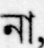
না,
